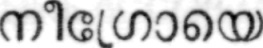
നീഗ്രോയെ
